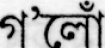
গ'লোঁ
